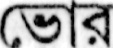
ভোর
